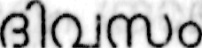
ദിവസം
